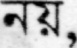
নয়,
